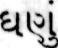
ઘણું
